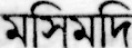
মসিমদি
